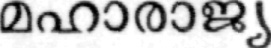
മഹാരാജ്യ
